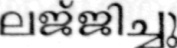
ലജ്ജിച്ചു
